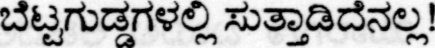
ಬೆಟ್ಟಗುಡ್ಡಗಳಲ್ಲಿಸುತ್ತಾಡಿದೆನಲ್ಲ!
